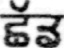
ਛੱਡ
